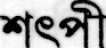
শৎপী
